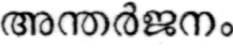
അന്തര്‍ജനം
